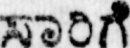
ಸಾರಿಗೆ
